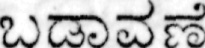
ಬಡಾವಣೆ
